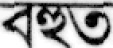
বহুত
